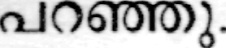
പറഞ്ഞു.
